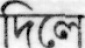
দিলে
